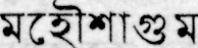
মহৌশাগুম
